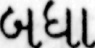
બધા
